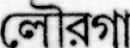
লৌরগা
